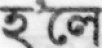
হ'লে
